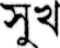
সুখ
